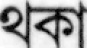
থকা
